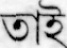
তাই
